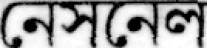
নেসনেল
